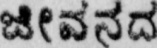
ಜೀವನದ
